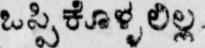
ಒಪ್ಪಿಕೊಳ್ಳಲಿಲ್ಲ.
